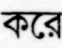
করে
